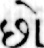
છો
